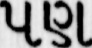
પણ
